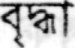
বৃদ্ধা
